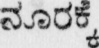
ನೂರಕ್ಕೆ
